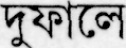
দুফালে
